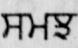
ਸਮਝ
